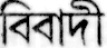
বিবাদী
